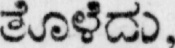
ತೊಳೆದು,
